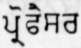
ਪ੍ਰੋਫੈਸਰ
